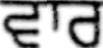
ਵਾਰ
